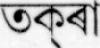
তক্‌ৰা
